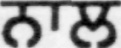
ਨਾਲ
